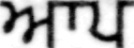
ਆਪ
